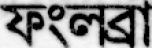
ফংলব্রা
